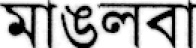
মাঙলবা
